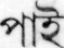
পাই
